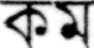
কম
